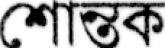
শোন্তক
